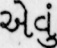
એવું
